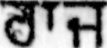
ਰਾਜ
